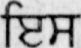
ਇਸ
